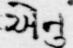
એનું
